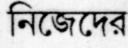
নিজেদের
